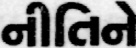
નીતિને
